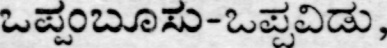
ಒಪ್ಪಂಬೂಸು-ಒಪ್ಪವಿಡು,
